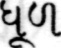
ધૂળ
